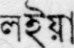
লইয়া
